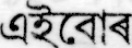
এইবোৰ
